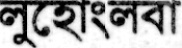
লুহোংলবা
